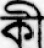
কী
